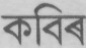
কবিৰ
